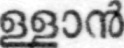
ള്ളാന്‍
